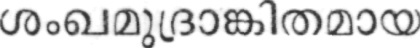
ശംഖമുദ്രാങ്കിതമായ
